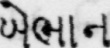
બેભાન
